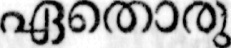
ഏതൊരു
